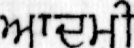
ਆਦਮੀ
